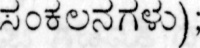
ಸಂಕಲನಗಳು);
